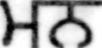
ਮਨ
